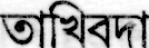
তাখিবদা
